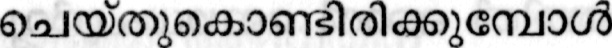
ചെയ്തുകൊണ്ടിരിക്കുമ്പോള്‍
